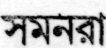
সমনরা
